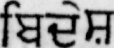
ਬਿਦੇਸ਼
